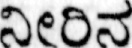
ನೀರಿನ
